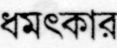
ধমত্কার
